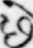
છે
